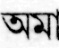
অমা
